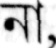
না,
